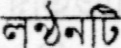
লন্ঠনটি
